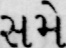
સમે
